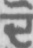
ਦੋ
